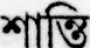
শান্তি
